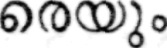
രെയും
